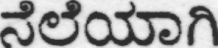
ನೆಲೆಯಾಗಿ
